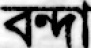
বন্দা
